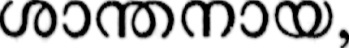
ശാന്തനായ,
